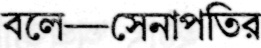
বলে–সেনাপতির
